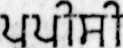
ਪਪੀਸੀ
